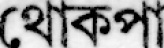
থোকপা
